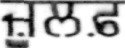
ਜ਼ੁਲਫ਼
